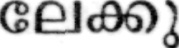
ലേക്കു
